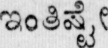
ಇಂತಿಷ್ಟೇ
